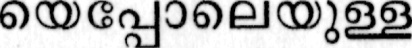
യെപ്പോലെയുള്ള
